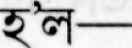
হ'ল-
